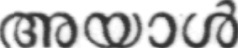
അയാള്‍
